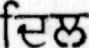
ਦਿਲ
